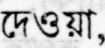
দেওয়া,
